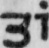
ਤਾਂ
